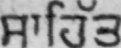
ਸਾਹਿੱਤ
